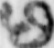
છ
